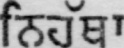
ਨਿਹੱਥਾ
